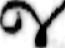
જ
